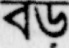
বড়
